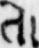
તો
